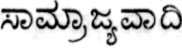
ಸಾಮ್ರಾಜ್ಯವಾದಿ
